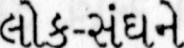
લોક-સંઘને
